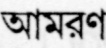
আমরণ
